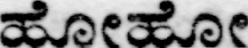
ಹೋಹೋ
